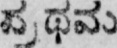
ಪ್ರಥಮ
